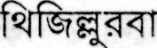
থিজিল্লুরবা
